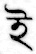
ই
